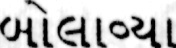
બોલાવ્યા
